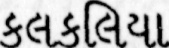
કલકલિયા
